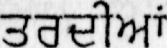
ਤਰਦੀਆਂ
